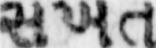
સખત
